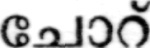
ചോറ്
